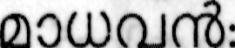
മാധവന്‍:
